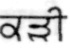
ਕੜੀ
